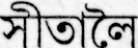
সীতালৈ
